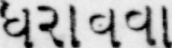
ધરાવવા
